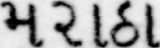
મરાઠા
